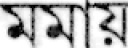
মমায়
